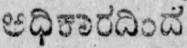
ಅಧಿಕಾರದಿಂದೆ
